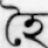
হৈ
